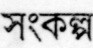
সংকল্প
